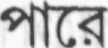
পারে
